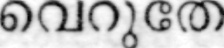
വെറുതേ
